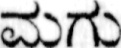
ಮಗು
